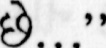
છે..."
